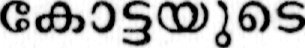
കോട്ടയുടെ
